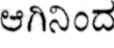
ಆಗಿನಿಂದ
